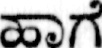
ಹಾಗೆ
